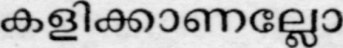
കളിക്കാണല്ലോ
